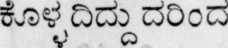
ಕೊಳ್ಳದಿದ್ದುದರಿಂದ
